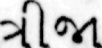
ત્રીજા
